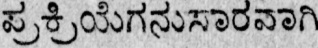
ಪ್ರಕ್ರಿಯೆಗನುಸಾರವಾಗಿ
